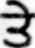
ਤੇ
